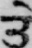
ਤੇ
